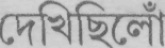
দেখিছিলোঁ
